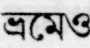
ভ্রমেও
